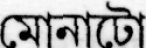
মোনাটো
